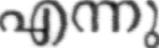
എന്നു
